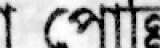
পোন্নি
